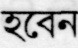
হবেন
